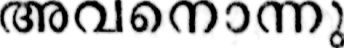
അവനൊന്നു
